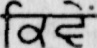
ਕਿਵੇਂ
